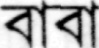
বাবা
